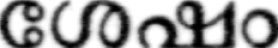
ശേഷം
